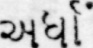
અર્ધાં
